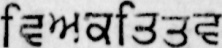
ਵਿਅਕਤਿਤਵ
